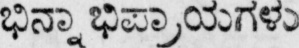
ಭಿನ್ನಾಭಿಪ್ರಾಯಗಳು
